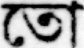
তো
